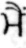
ਮੈਂ
